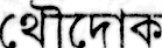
থৌদোক
